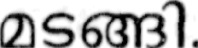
മടങ്ങി.
